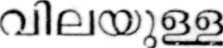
വിലയുള്ള
